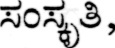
ಸಂಸ್ಕೃತಿ,
